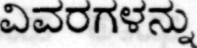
ವಿವರಗಳನ್ನು
